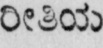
ರೀತಿಯ
